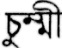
চুম্মী
